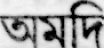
অমদি
